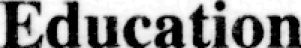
Education
